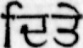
ਦਿਤੇ
